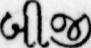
બીજી
